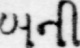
બની
